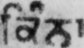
ਕਿੰਨਾ
